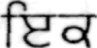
ਇਕ
